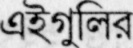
এইগুলির
